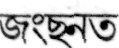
জংছনত
